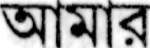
আমার
